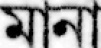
মানা
